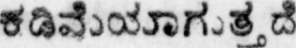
ಕಡಿಮೆಯಾಗುತ್ತದೆ
